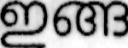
ഇങ്ങ
